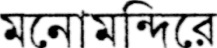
মনোমন্দিরে
